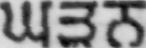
ਘੜਨ
